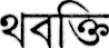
থবক্তি
